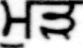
ਮੁੜ
